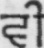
ਵੀ
